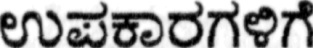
ಉಪಕಾರಗಳಿಗೆ
